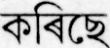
কৰিছে
